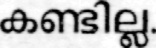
കണ്ടില്ല.
